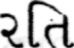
રતિ
